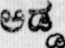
ಅಡ್ಡ
